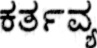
ಕರ್ತವ್ಯ
